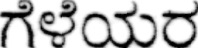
ಗೆಳೆಯರ
